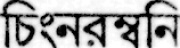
চিংনরম্বনি
